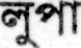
লুপা
